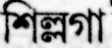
শিল্লগা
